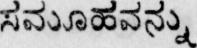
ಸಮೂಹವನ್ನು
